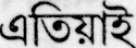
এতিয়াই
